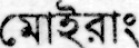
মোইরাং
